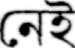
নেই
